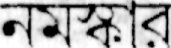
নমস্কার
